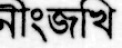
নীংজখি
